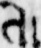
તો
